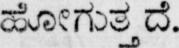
ಹೋಗುತ್ತದೆ.
